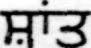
ਸ਼ਾਂਤ
